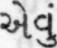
એવું
